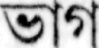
ভাগ
